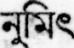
নু্মিৎ
